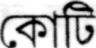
কোটি
